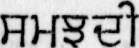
ਸਮਝਦੀ
